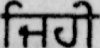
ਜਿਹੀ
